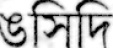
ঙসিদি
